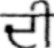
ਦੀ
